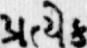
પ્રત્યેક
